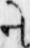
ને
